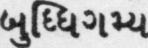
બુધ્ધિગમ્ય
